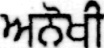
ਅਨੋਖੀ
